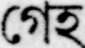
গেহ
